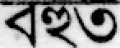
বহুত
